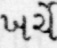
ખર્ચે
